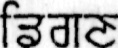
ਡਿਗਣ
